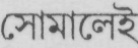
সোমালেই
